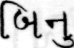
બિનુ
